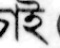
চাই
